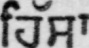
ਹਿੱਸਾ
